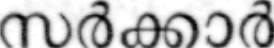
സര്‍ക്കാര്‍
